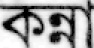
কন্না
